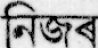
নিজৰ
